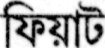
ফিয়াট
